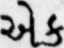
એક
